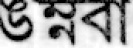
ঙম্নবা
